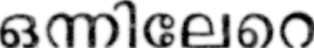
ഒന്നിലേറെ
